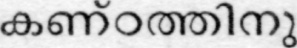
കണ്ഠത്തിനു
